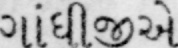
ગાંધીજીએ
